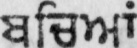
ਬਚਿਆਂ
